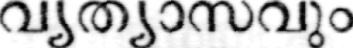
വ്യത്യാസവും
